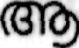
ആ
